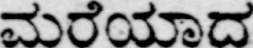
ಮರೆಯಾದ
